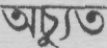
অচ্যুত
